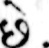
છે.
